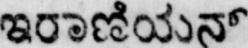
ಇರಾಣಿಯನ್
